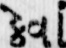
કેવાં
